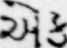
એક
